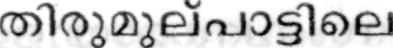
തിരുമുല്പാട്ടിലെ
